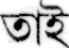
তাই
